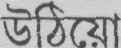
উঠিয়ো
